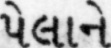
પેલાને
